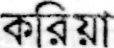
করিয়া
